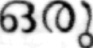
ഒരു
